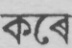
কৰে
